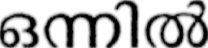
ഒന്നില്‍
